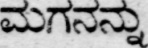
ಮಗನನ್ನು
